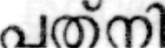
പത്നി
